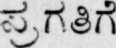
ಪ್ರಗತಿಗೆ
